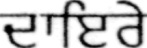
ਦਾਇਰੇ
